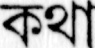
কথা
